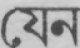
যেন
